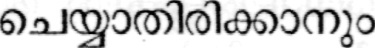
ചെയ്യാതിരിക്കാനും
